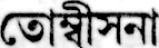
তোম্বীসনা
